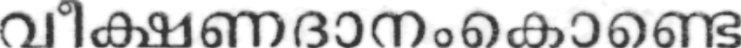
വീക്ഷണദാനംകൊണ്ടെ
